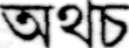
অথচ
